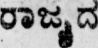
ರಾಜ್ಯದ
